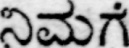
ನಿಮಗೆ
